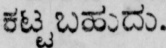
ಕಟ್ಟಬಹುದು.
